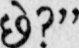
છે?"
